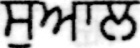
ਸੁਆਲ
